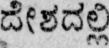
ದೇಶದಲ್ಲಿ
